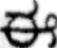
ಈ
